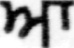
ਆ
